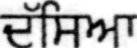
ਦੱਸਿਆ
